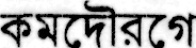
কমদৌরগে
